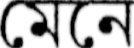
মেনে
